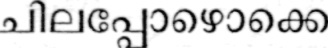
ചിലപ്പോഴൊക്കെ
